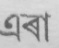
এৰা
